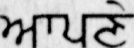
ਆਪਣੇ
